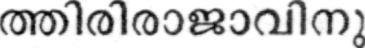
ത്തിരിരാജാവിനു
